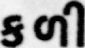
કળી
